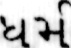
ધર્મ
